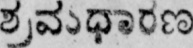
ಶ್ರಮಧಾರಣ
